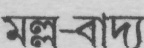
মল্ল-বাদ্য
